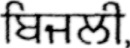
ਬਿਜਲੀ,
